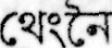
থেংনৈ
